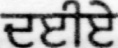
ਦਈਏ
